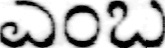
ಎಂಬ
